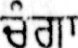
ਚੰਗਾ
